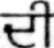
ਦੀ
